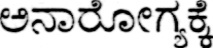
ಅನಾರೋಗ್ಯಕ್ಕೆ
